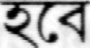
হবে
